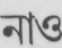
নাও
